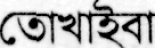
তোখাইবা
